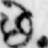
છે.
